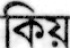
কিয়
